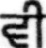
ਵੀ
